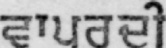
ਵਾਪਰਦੀ
